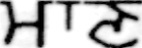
ਮਾਣ
